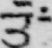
ਤੋਂ
